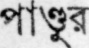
পাণ্ডুর
